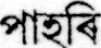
পাহৰি
